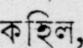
কহিল,
